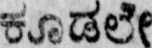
ಕೂಡಲೇ
